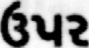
ઉપર
